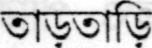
তাড়াতাড়ি
